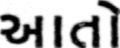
આતો
